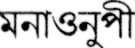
মনাওনুপী
